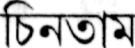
চিনতাম
